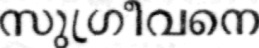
സുഗ്രീവനെ
